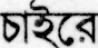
চাইরে
